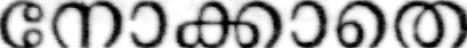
നോക്കാതെ
